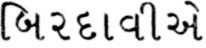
બિરદાવીએ
